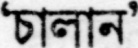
‘চালান’
